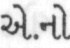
એ.નો
